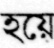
হয়ে
